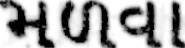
મળવા
